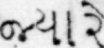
જ્યારે
